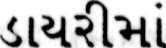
ડાયરીમાં
